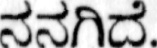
ನನಗಿದೆ.
